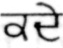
ਕਦੇ
